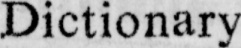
Dictionary
